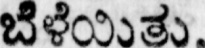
ಬೆಳೆಯಿತು.
